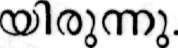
യിരുന്നു.
